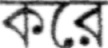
করে
